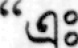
"এঃ
